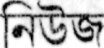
নিউজ
